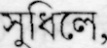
সুধিলে,
